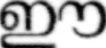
ഈ
